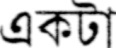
একটা
